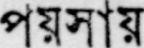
পয়সায়
